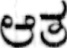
ಆತ
